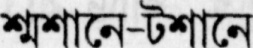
শ্মশানে-টশানে
